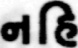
નહિ
